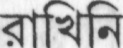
রাখিনি
